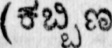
(ಕಬ್ಬಿಣ
